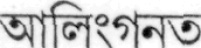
আলিংগনত
